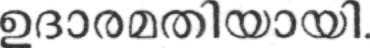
ഉദാരമതിയായി.
